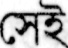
সেই
